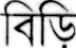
বিড়ি
